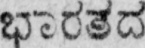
ಭಾರತದ
